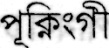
পূক্নিংগী
